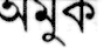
অমুক
